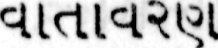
વાતાવરણ
